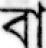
বা
